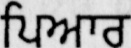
ਪਿਆਰ
